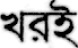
খরই
